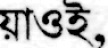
য়াওই,
